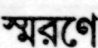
স্মরণে
